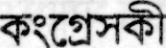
কংগ্রেসকী
